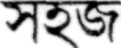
সহজ
